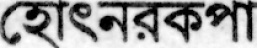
হোৎনরকপা
